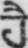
ਹੈ
